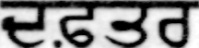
ਦਫ਼ਤਰ
